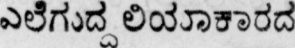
ಎಲೆಗುದ್ದಲಿಯಾಕಾರದ
